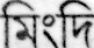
মিংদি
